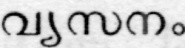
വ്യസനം
